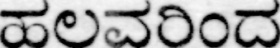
ಹಲವರಿಂದ
